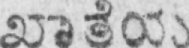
ಖಾತೆಯ
